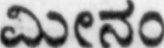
ಮೀನಂ
